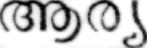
ആര്യ
